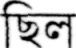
ছিল
